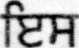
ਇਸ
